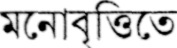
মনোবৃত্তিতে
